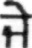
ਜੇ
